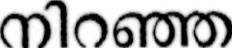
നിറഞ്ഞ
